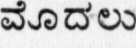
ಮೊದಲು
